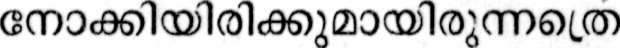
നോക്കിയിരിക്കുമായിരുന്നത്രെ
